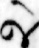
જે
